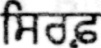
ਸਿਰਫ਼
